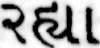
રહ્યા
